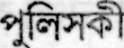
পুলিসকী
